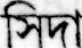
সিদা
